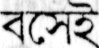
বসেই
